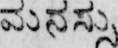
ಮನಸ್ಸು
